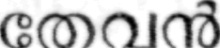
തേവന്‍
